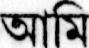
আমি
